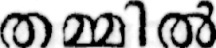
തമ്മില്‍
